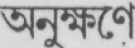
অনুক্ষণে
